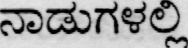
ನಾಡುಗಳಲ್ಲಿ
